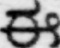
ಈ
